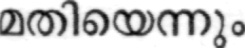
മതിയെന്നും
